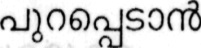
പുറപ്പെടാന്‍
